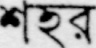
শহর
